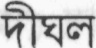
দীঘল
